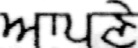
ਆਪਣੇ
